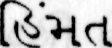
હિંમત
